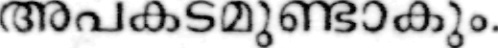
അപകടമുണ്ടാകും.
